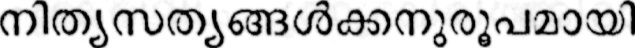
നിത്യസത്യങ്ങള്‍ക്കനുരൂപമായി
